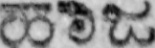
ಹಾಜ
